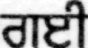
ਗਈ
